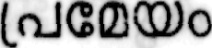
പ്രമേയം
